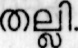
തല്ലി.
